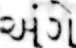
અંગે
